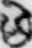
છે
